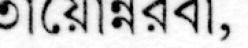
তায়োন্নরবা,
